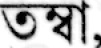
তম্বা,
